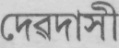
দেৱদাসী
